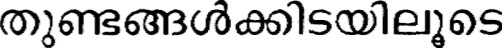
തുണ്ടങ്ങള്‍ക്കിടയിലൂടെ
